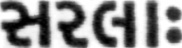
સરલાઃ
